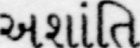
અશાંતિ
